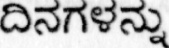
ದಿನಗಳನ್ನು
